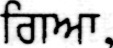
ਗਿਆ,
